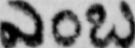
ಎಂಬ
